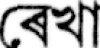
ৰেখা
